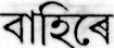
বাহিৰে
